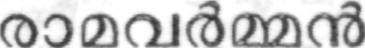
രാമവര്‍മ്മന്‍
